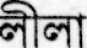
লীলা
